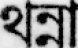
থন্না
